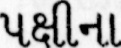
પક્ષીના
